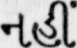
નહીં
